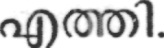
എത്തി.
